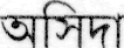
অসিদা
